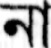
না
